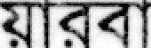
য়ারবা
